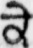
ਕੇ
